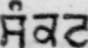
ਸੰਕਟ
